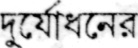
দুর্যোধনের
